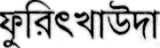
ফুরিৎখাউদা
